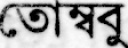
তোম্ববু
